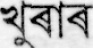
খুৰাৰ
